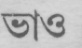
ভাও
